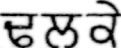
ਢਲਕੇ
